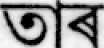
তাৰ
